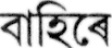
বাহিৰে
